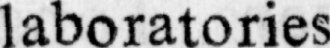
laboratories
